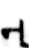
ન
